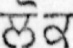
ਲੋਕ
